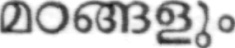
മഠങ്ങളും
